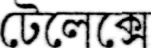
টেলেক্সে
